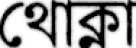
থোক্না
